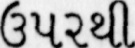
ઉપરથી
